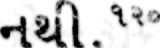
નથી.૧૨૦
